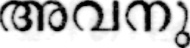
അവനു
